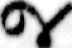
જ
